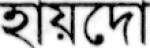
হায়দো
